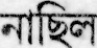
নাছিল
